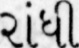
રાંધી
